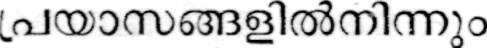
പ്രയാസങ്ങളില്‍നിന്നും
